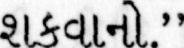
શકવાનો."
